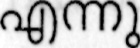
എന്നു
